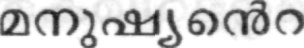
മനുഷ്യന്റെ
